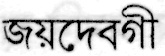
জয়দেবগী
